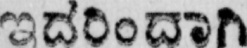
ಇದರಿಂದಾಗಿ
